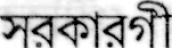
সরকারগী
